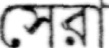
সেরা
